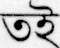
তই
